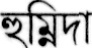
হুম্নিদা
